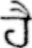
ਹੈ
